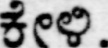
ಕೇಳಿ.
